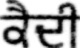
ਕੈਦੀ
